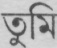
তুমি
